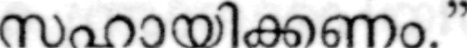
സഹായിക്കണം.”
